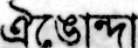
ঐঙোন্দা
